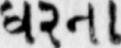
ઘરના
